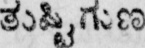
ತುಷ್ಟಿಗುಣ
